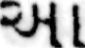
આ
